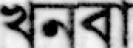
খনবা
